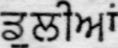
ਡੁਲੀਆਂ
